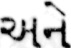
અને
